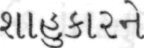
શાહુકારને
